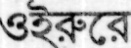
ওইরুরে
